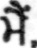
ਮੈਂ,
